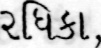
રધિકા,
